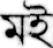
মই
